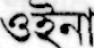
ওইনা
